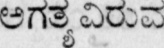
ಅಗತ್ಯವಿರುವ
